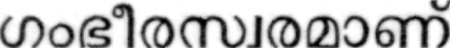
ഗംഭീരസ്വരമാണ്
